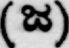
(ಜ)
